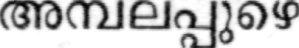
അമ്പലപ്പുഴെ
